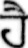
ਹੈ
